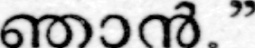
ഞാന്‍.”
